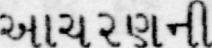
આચરણની
